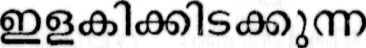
ഇളകിക്കിടക്കുന്ന
